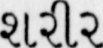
શરીર
